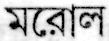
মরোল
